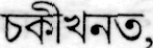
চকীখনত,
